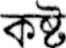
কষ্ট
